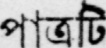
পাত্রটি
